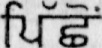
ਪਿੱਛੋਂ
